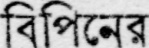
বিপিনের
